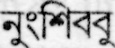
নুংশিববু
